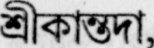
শ্রীকান্তদা,
